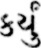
કર્યું
